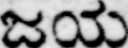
ಜಯ
